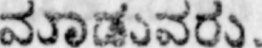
ಮಾಡುವರು.
